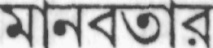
মানবতার
